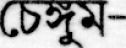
চেঙ্গুম-
